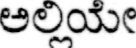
ಅಲ್ಲಿಯೇ
